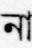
না
